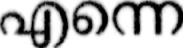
എന്നെ
